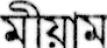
মীয়াম
